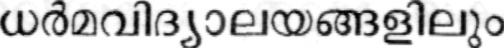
ധര്‍മവിദ്യാലയങ്ങളിലും
